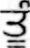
ਤੂੰ
